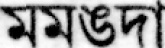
মমঙদা
